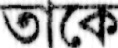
তাকে
